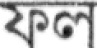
ফল
